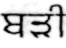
ਬੜੀ
